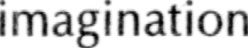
imagination
